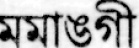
মমাঙগী
